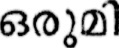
ഒരുമി
